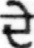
ਦੇ
